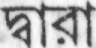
দ্বারা
